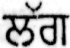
ਲੱਗ
